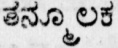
ತನ್ಮೂಲಕ
